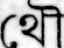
থৌ
